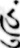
હું
